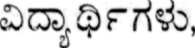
ವಿದ್ಯಾರ್ಥಿಗಳು,
